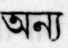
অন্য
